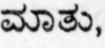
ಮಾತು,
